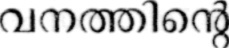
വനത്തിന്റെ
